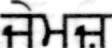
ਜੇਮਜ਼
